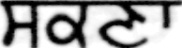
ਸਕਣਾ
